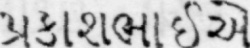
પ્રકાશભાઈએ
